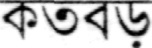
কতবড়
